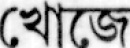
খোজে
